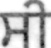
ਸੀ
